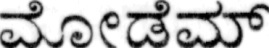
ಮೊಡೆಮ್
